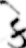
કે
